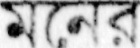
মনের
